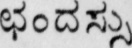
ಛಂದಸ್ಸು
